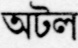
অটল
